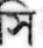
সি
